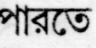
পারতে
